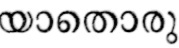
യാതൊരു
